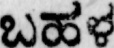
ಬಹಳ
